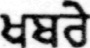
ਖਬਰੇ
